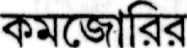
কমজোরির
